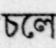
চলে
